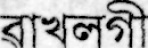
ৱাখলগী
